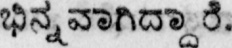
ಭಿನ್ನವಾಗಿದ್ದಾರೆ.
